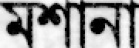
মশানা
